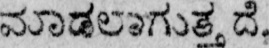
ಮಾಡಲಾಗುತ್ತದೆ.
